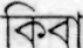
কিবা
